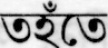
তহঁতে
